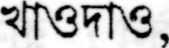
খাওদাও,
